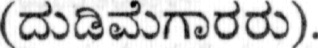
(ದುಡಿಮೆಗಾರರು).
